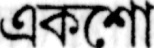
একশো
